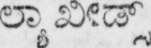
ಲ್ಯಾಖೀಡ್ಸ್
